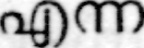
എന്ന
